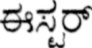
ಈಸ್ಟರ್
